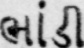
ભાંડી
